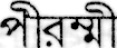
পীরম্মী
